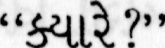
"ક્યારે?"
